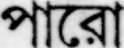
পারো
